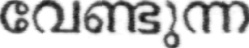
വേണ്ടുന്ന
